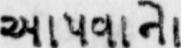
આપવાનો
